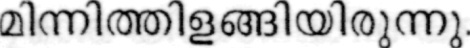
മിന്നിത്തിളങ്ങിയിരുന്നു.
